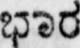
ಭಾರ
